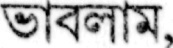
ভাবলাম,
